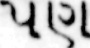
પણ
